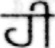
ਹੀ
